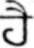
ਹੈ
